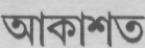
আকাশত
